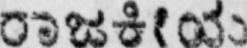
ರಾಜಕೀಯ
